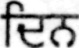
ਦਿਨ
